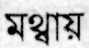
মথ্বায়
